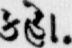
કહો.
